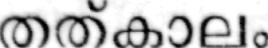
തത്കാലം
